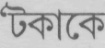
'টকাকে
